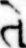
તે
